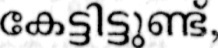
കേട്ടിട്ടുണ്ട്,
